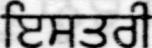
ਇਸਤਰੀ
